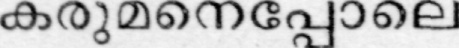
കരുമനെപ്പോലെ
